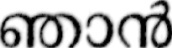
ഞാന്‍
